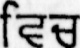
ਵਿਚ
